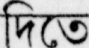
দিতে
